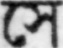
সে
